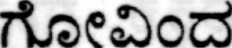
ಗೋವಿಂದ
